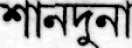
শানদুনা
